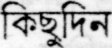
কিছুদিন
